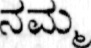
ನಮ್ಮ
